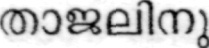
താജലിനു
